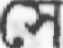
সে
